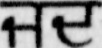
ਜਦ
